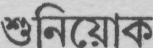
শুনিয়োক
